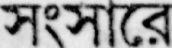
সংসারে
